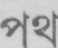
পথ
